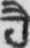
ਹੈ
